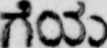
ಗೆಯ
